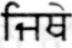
ਜਿਥੇ
